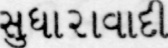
સુધારાવાદી
